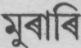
মুৰাৰি
